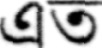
এত
